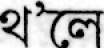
থ'লে
